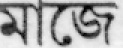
মাজে
